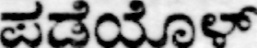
ಪಡೆಯೊಳ್
